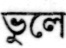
ভুলে
